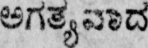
ಅಗತ್ಯವಾದ
